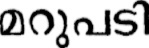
മറുപടി
